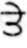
ਤੇ
